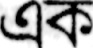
এক
